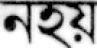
নহয়
